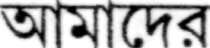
আমাদের
